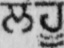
ਲਹੂ
